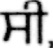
ਸੀ,
